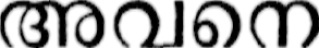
അവനെ
